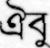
ঐবু
